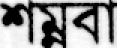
শম্নবা
